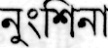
নুংশিনা
